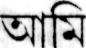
আমি
